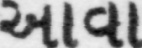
આવા
